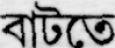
বাটতে
